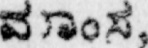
ಮಾಂಸ,
